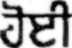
ਹੋਈ
